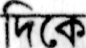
দিকে
